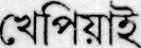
খেপিয়াই
